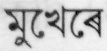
মুখেৰে
